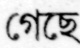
গেছে
